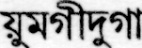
য়ুমগীদুগা
